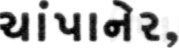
ચાંપાનેર,
